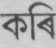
কৰি
